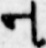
ન
